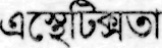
এস্থেটিক্সতা
